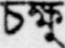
চক্ষু
